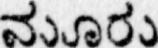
ಮೂರು
